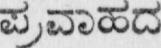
ಪ್ರವಾಹದ
